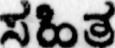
ಸಹಿತ
